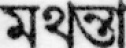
মথন্তা
